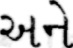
અને
